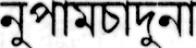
নুপামচাদুনা
